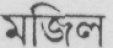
মজিল
